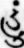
હું
